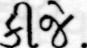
કીજે.
